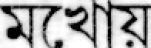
মখোয়
